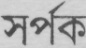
সৰ্পক
